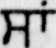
ਸਾਂ
